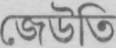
জেউতি
